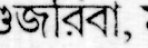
শুজরিবা,
